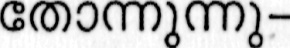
തോന്നുന്നു-
